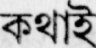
কথাই
